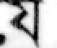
যে
